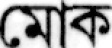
মোক
